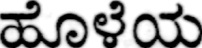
ಹೊಳೆಯ
